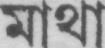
মাথা
